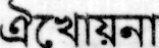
ঐখোয়না
